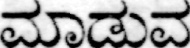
ಮಾಡುವ
